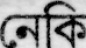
নেকি
